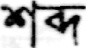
শব্দ
